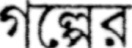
গল্পের
